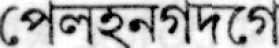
পেলহনগদগে
